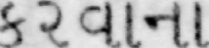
કરવાના
